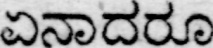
ಏನಾದರೂ
